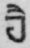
ਹੈ
